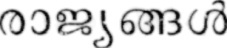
രാജ്യങ്ങള്‍
